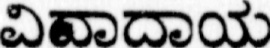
ವಿವಾದಾಯ
